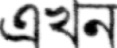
এখন
